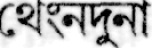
থেংনদুনা
